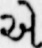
એ
